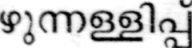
ഴുന്നള്ളിപ്പ്
